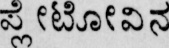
ಪ್ಲೇಟೋವಿನ
